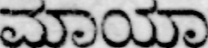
ಮಾಯಾ
